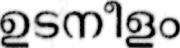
ഉടനീളം
